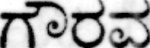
ಗೌರವ
